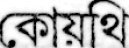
কোয়থি
